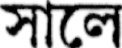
সালে
